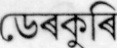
ডেৰকুৰি
